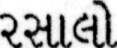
રસાલો
